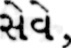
સેવે,
